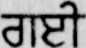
ਗਈ
